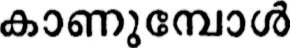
കാണുമ്പോള്‍
